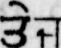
ਤੇਜ
